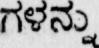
ಗಳನ್ನು
